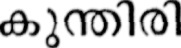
കുന്തിരി
